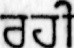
ਰਹੀ
